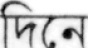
দিনে
